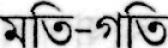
মতি-গতি
